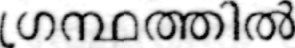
ഗ്രന്ഥത്തില്‍
